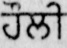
ਹੌਲੀ
